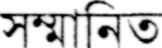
সম্মানিত
